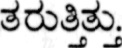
ತರುತ್ತಿತ್ತು.
